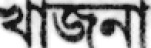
খাজনা
